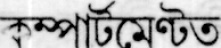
কম্পাৰ্টমেণ্টত
